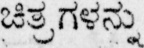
ಚಿತ್ರಗಳನ್ನು
